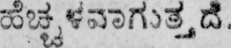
ಹೆಚ್ಚಳವಾಗುತ್ತದೆ.
